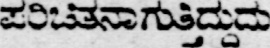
ಪರಿಚಿತನಾಗುತ್ತಿದ್ದುದು
